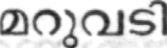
മറുവടി
